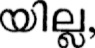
യില്ല,
